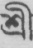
শ্ৰী
